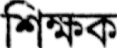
শিক্ষক
